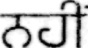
ਨਹੀਂ
